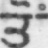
ਤੋਂ
